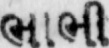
ભાભી
